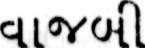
વાજબી
